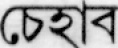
চেহাব
